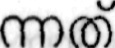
ന്നത്
